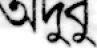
অদুবু
